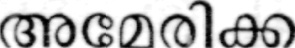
അമേരിക്ക
